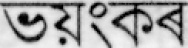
ভয়ংকৰ
